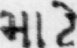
માટે
